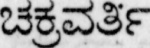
ಚಕ್ರವರ್ತಿ
